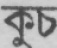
কুচ
